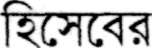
হিসেবের
